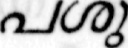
പശു
